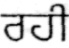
ਰਹੀ
